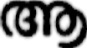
ആ
